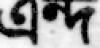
এন্দ
